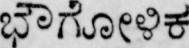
ಭೌಗೋಳಿಕ
